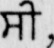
ਸੀ,
